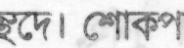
শোকপ
